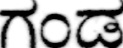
ಗಂಡ
